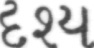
દૃશ્ય
